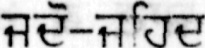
ਜਦੋ-ਜਹਿਦ
